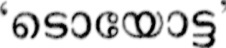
‘ടൊയോട്ട'
